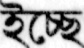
ইচ্ছে
